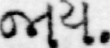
જાય.
